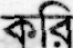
করি
